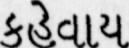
કહેવાય
